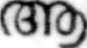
ആ
